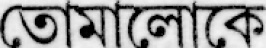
তোমালোকে
